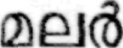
മലര്‍
